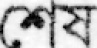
শেষ
